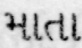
માતા
